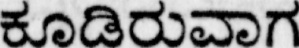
ಕೂಡಿರುವಾಗ
